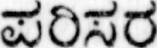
ಪರಿಸರ
